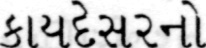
કાયદેસરનો
